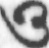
ও
